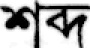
শব্দ
